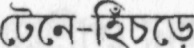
টেনে-হিঁচড়ে
